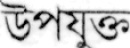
উপযুক্ত
